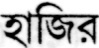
হাজির
